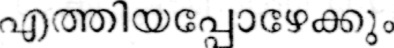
എത്തിയപ്പോഴേക്കും
